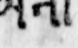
બની
